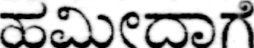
ಹಮೀದಾಗೆ
